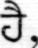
ਹੈ,
